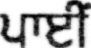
ਪਾਈਂ
